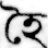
হৈ
